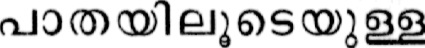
പാതയിലൂടെയുള്ള
